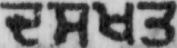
ਦਸਖਤ
